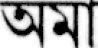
অমা
